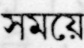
সময়ে
